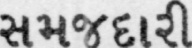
સમજદારી
